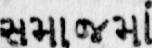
સમાજમાં
